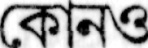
কোনও
